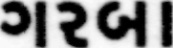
ગરબા
